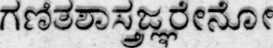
ಗಣಿತಶಾಸ್ತ್ರಜ್ಞರೇನೋ
